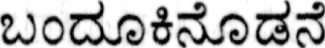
ಬಂದೂಕಿನೊಡನೆ
